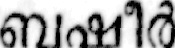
ബഷീര്‍
